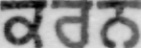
ਕਰਨ
